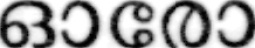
ഓരോ
